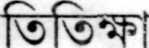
তিতিক্ষা
